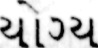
યોગ્ય
